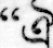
“ঐ
